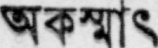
অকস্মাৎ
